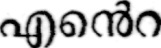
എന്റെ
